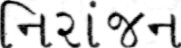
નિરાંજન
